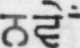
ਨਵੇਂ
